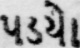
પડ્યો
